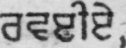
ਰਵਈਏ,
